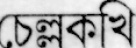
চেল্লকখি
